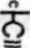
ਨੂੰ
